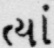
ત્યાં
